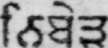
ਨਿਬੇੜ
